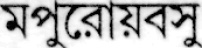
মপুরোয়বসু
